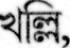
খল্লি,
